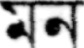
মন
